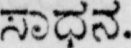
ಸಾಧನ.
